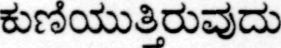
ಕುಣಿಯುತ್ತಿರುವುದು
